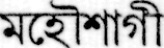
মহৌশাগী
